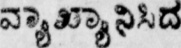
ವ್ಯಾಖ್ಯಾನಿಸಿದ
